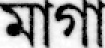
মাগা
